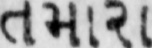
તમારા
